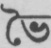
ভৈ
